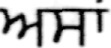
ਅਸਾਂ
